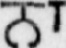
ਨਾ
